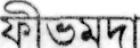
ফীভমদা
